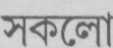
সকলো
